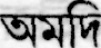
অমদি
